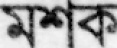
মশক
